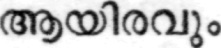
ആയിരവും
